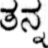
ತನ್ನ
